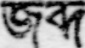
জব্দ
